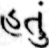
હતું
